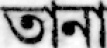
তানা
